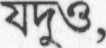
যদুও,
